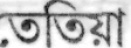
তেতিয়া
